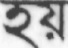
হয়
